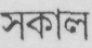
সকাল
